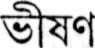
ভীষণ
